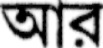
আর
